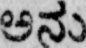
ಅನು
